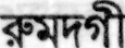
রুমদগী
